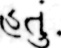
હતું.
